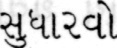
સુધારવો
